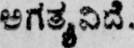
ಅಗತ್ಯವಿದೆ.
